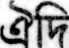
ঐদি
